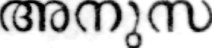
അനുസ
